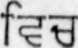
ਵਿਚ
